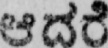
ಆದರೆ
